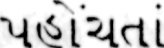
પહોંચતાં
